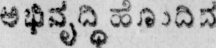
ಅಭಿವೃದ್ಧಿಹೊಂದಿದ
